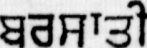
ਬਰਸਾਤੀ
